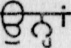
ਉਨ੍ਹਾਂ
